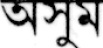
অসুম
